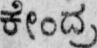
ಕೇಂದ್ರ
